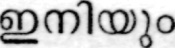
ഇനിയും
